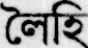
লৈহি
